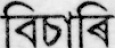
বিচাৰি
